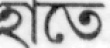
হাতে
